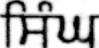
ਸਿੰਘ
